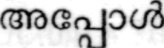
അപ്പോള്‍
